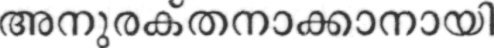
അനുരക്തനാക്കാനായി
